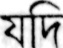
যদি
